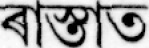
ৰাস্তাত
